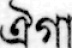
ঐগা
